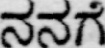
ನನಗೆ
